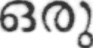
ഒരു
